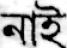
নাই
